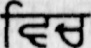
ਵਿਚ
